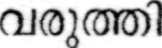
വരുത്തി
